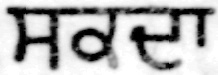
ਸਕਦਾ
